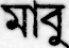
মাবু
